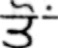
ਤੋਂ
